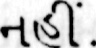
નહીં.
